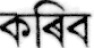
কৰিব
